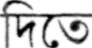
দিতে
